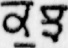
ਕੁਝ
